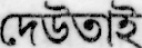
দেউতাই
